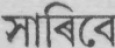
সাৰিবে
